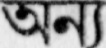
অন্য
